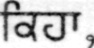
ਕਿਹਾ,
